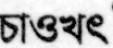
চাওখৎ
